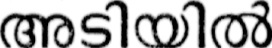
അടിയില്‍
